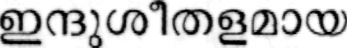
ഇന്ദുശീതളമായ
